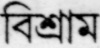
বিশ্রাম
